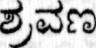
ಶ್ರವಣ
